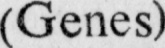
(Genes)
